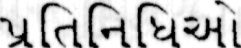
પ્રતિનિધિઓ
